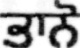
ਭਾਨੋ
